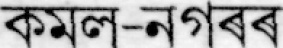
কমল-নগৰৰ
